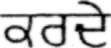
ਕਰਦੇ
